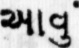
આવું
